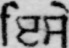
ਇਸੇ
